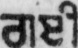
ਗਈ
